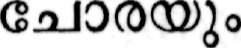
ചോരയും
